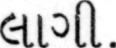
લાગી.
